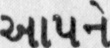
આપને
